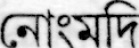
নোংমদি
